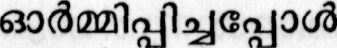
ഓര്‍മ്മിപ്പിച്ചപ്പോള്‍
